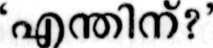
‘എന്തിന്?’
